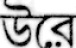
উরে
